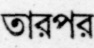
তারপর
